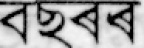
বছৰৰ
